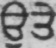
ਉਤੇ
